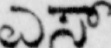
ಎಸ್
